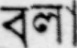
বলা
